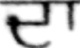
ਦਾ
